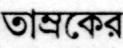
তাম্রকের
